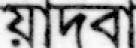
য়াদবা
